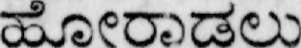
ಹೋರಾಡಲು
